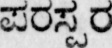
ಪರಸ್ಪರ
